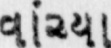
વાંચ્યા
